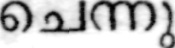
ചെന്നു
